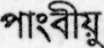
পাংবীয়ু
